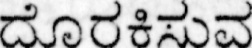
ದೊರಕಿಸುವ
